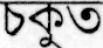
চকুত
